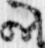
જો
